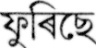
ফুৰিছে
